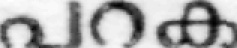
പറക
